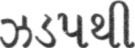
ઝડપથી
